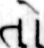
તો
